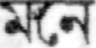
মনে
